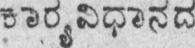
ಕಾರ್ಯವಿಧಾನದ
